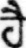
ਹੈ
